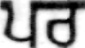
ਪਰ
